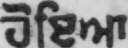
ਹੋਇਆ
